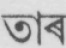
তাৰ
